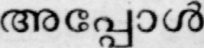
അപ്പോള്‍
